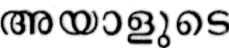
അയാളുടെ
